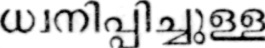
ധ്വനിപ്പിച്ചുള്ള
